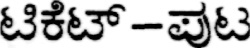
ಟಿಕೆಟ್-ಪುಟ
